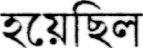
হয়েছিল
